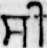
ਸੀ
